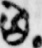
છે.
